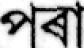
পৰা
